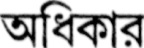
অধিকার
